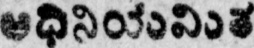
ಅಧಿನಿಯಮಿತ
